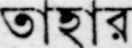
তাহার
